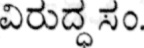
ವಿರುದ್ಧಸಂ.
